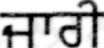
ਜਾਰੀ
